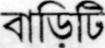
বাড়িটি
